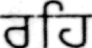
ਰਹਿ
